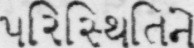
પરિસ્થિતિને
